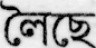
লৈছে
